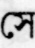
সে
